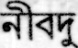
নীবদু
